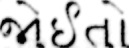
જોઈતો
